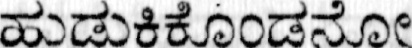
ಹುಡುಕಿಕೊಂಡನೋ
